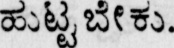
ಹುಟ್ಟಬೇಕು.
